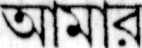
আমার
